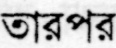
বড়ো
